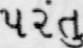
પરંતુ
